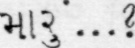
મારું....?
